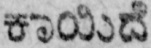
ಕಾಯಿದೆ
